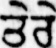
ਤੇਰੇ
